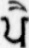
ਪੈ
